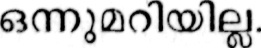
ഒന്നുമറിയില്ല.
